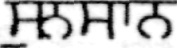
ਸੁਨਸਾਨ
